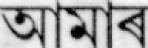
আমাৰ
